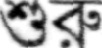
শুরু
